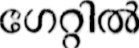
ഗേറ്റില്‍
